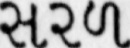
સરળ
